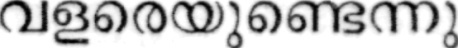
വളരെയുണ്ടെന്നു
